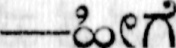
-ಹೀಗೆ
